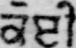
ਕੋਈ
